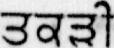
ਤਕੜੀ
